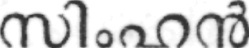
സിംഹന്‍
